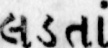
લડતાં
